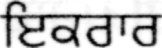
ਇਕਰਾਰ
